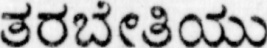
ತರಬೇತಿಯು
